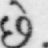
છે.
